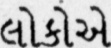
લોકોએ
